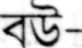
বউ-
